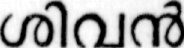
ശിവന്‍
